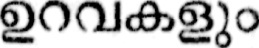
ഉറവകളും
